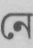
নে
